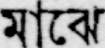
মাঝে
